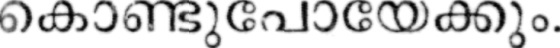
കൊണ്ടുപോയേക്കും.
